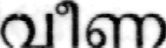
വീണ
